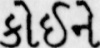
કોઈને
